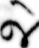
જે
